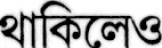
থাকিলেও
